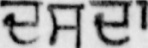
ਦਸਦਾ
